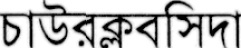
চাউরক্লবসিদা
